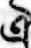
ঐ
